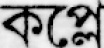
কপ্লে
